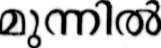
മുന്നില്‍
